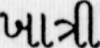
ખાત્રી
